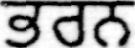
ਭਰਨ
